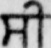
ਸੀ
